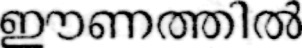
ഈണത്തില്‍
